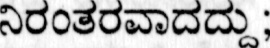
ನಿರಂತರವಾದದ್ದು;
